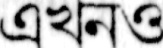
এখনও
